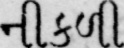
નીકળી
